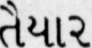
તૈયાર
